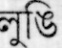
লুঙি
